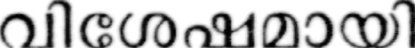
വിശേഷമായി
